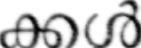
ക്കള്‍
